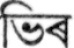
ভিৰ
